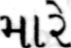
મારે
